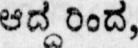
ಆದ್ದರಿಂದ,
